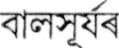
বালসূর্যৰ
